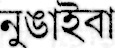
নুঙাইবা
